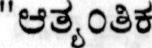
“ಆತ್ಯಂತಿಕ
